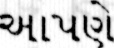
આપણે
